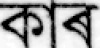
কাৰ
